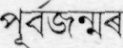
পূর্বজন্মৰ
